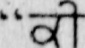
''ਕੀ
